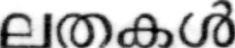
ലതകള്‍
